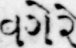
વગેરે
